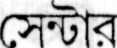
সেন্টার
